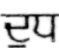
ਦੁਧ
